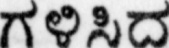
ಗಳಿಸಿದ
